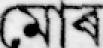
মোৰ
